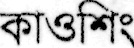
কাওশিং
